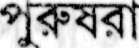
পুরুষরা
